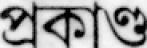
প্রকাণ্ড
